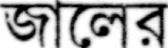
জালের
